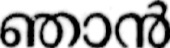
ഞാന്‍
